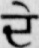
ਦੇ
